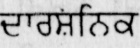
ਦਾਰਸ਼ਨਿਕ
